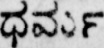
ಧರ್ಮ
